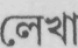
লেখা
